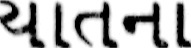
યાતના
